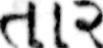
તાર
